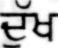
ਦੁੱਖ
